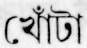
খোঁটা
